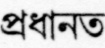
প্রধানত
